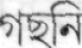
গছনি
